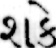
શકે
